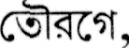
তৌরগে,
